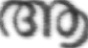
ആ
